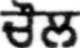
ਚੌਲ
